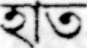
হাত
